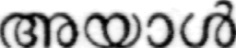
അയാള്‍
